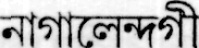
নাগালেন্দগী
